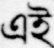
এই
